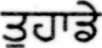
ਤੁਹਾਡੇ
